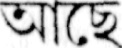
আছে
